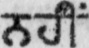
ਨਹੀਂ
